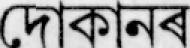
দোকানৰ
